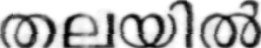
തലയില്‍
